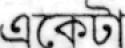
একেটা
